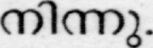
നിന്നു.
